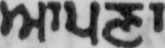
ਆਪਣਾ
